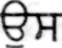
ਉਸ
